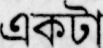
একটা
